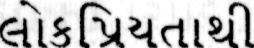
લોકપ્રિયતાથી
